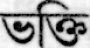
ভক্তি
